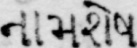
નામશેષ
